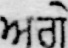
ਅਗੇ
